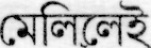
মেলিলেই
